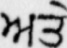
ਅਤੇ
